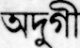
অদুগী
